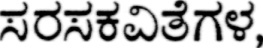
ಸರಸಕವಿತೆಗಳ,
